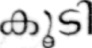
കൂടി
